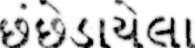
છંછેડાયેલા
